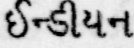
ઈન્ડીયન
